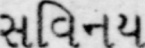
સવિનય
